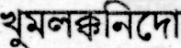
খুমলক্কনিদো
